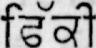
ਫਿੱਕੀ
